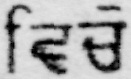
ਵਿਚੋ
